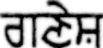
ਗਣੇਸ਼
